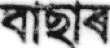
বাছাৰ
